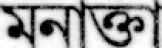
মনাক্তা
